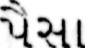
પૈસા
